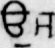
ਉਸ
